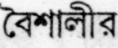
বৈশালীর
